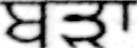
ਬੜਾ
